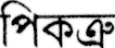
পিকত্রু
